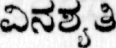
ವಿನಶ್ಯತಿ
